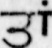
ਤਾਂ
